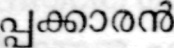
പ്പക്കാരന്‍
